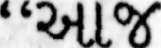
"આજ
